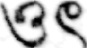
ওৎ
